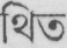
থিত
